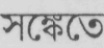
সঙ্কেতে
